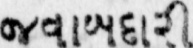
જવાબદારી
